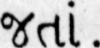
જતાં.
